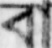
বা
